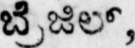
ಬ್ರೆಜಿಲ್,
